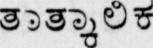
ತಾತ್ಕಾಲಿಕ
